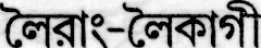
লৈরাং-লৈকাগী
